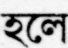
হলে
